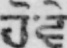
ਹੋਵੇ
